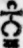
ਨੂੰ
